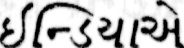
ઇન્ડિયાએ
